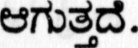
ಆಗುತ್ತದೆ.
